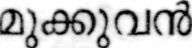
മുക്കുവന്‍
